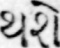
થશે
